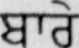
ਬਾਰੇ
